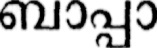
ബാപ്പാ
